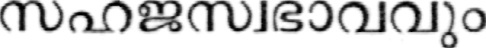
സഹജസ്വഭാവവും
